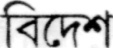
বিদেশ
